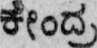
ಕೇಂದ್ರ
